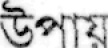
উপায়
